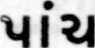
પાંચ
